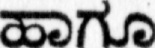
ಹಾಗೂ
